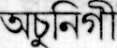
অচুনিগী
